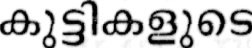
കുട്ടികളുടെ
